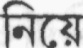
নিয়ে
